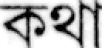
কথা
